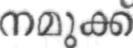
നമുക്ക്
